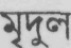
মৃদুল
